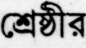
শ্রেষ্ঠীর
